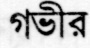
গভীর
